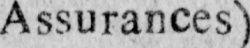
Assurances)
